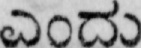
ಎಂದು
